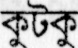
কুটকু
